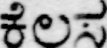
ಕೆಲಸ
